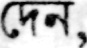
দেন,
